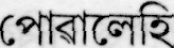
পোৱালেহি
